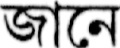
জানে
